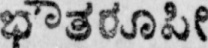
ಭೌತರೂಪೀ
